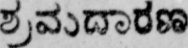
ಶ್ರಮದಾರಣ
